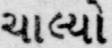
ચાલ્યો
